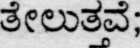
ತೇಲುತ್ತವೆ;
